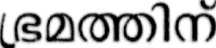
ഭ്രമത്തിന്
